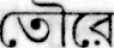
তৌরে
